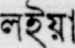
লইয়া
